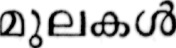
മുലകള്‍
